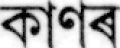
কাণৰ
